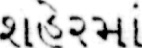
શહેરમાં
